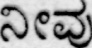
ನೀವು
